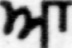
ਆ
